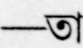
–তা
